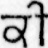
ਕੀ
